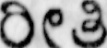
ರೀತಿ
